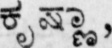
ಕೃಷ್ಣಾ,
